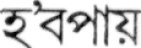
হ'বপায়
